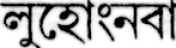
লুহোংনবা
